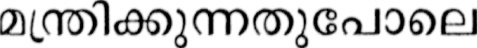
മന്ത്രിക്കുന്നതുപോലെ
